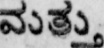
ಮತ್ತು
